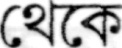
থেকে
